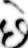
છે
